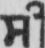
ਸੀ
